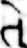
તે
